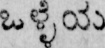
ಒಳ್ಳೆಯ
